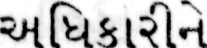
અધિકારીને
